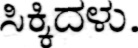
ಸಿಕ್ಕಿದಳು.
